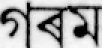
গৰম
